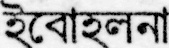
ইবোহলনা
